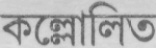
কল্লোলিত
